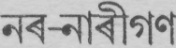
নৰ-নাৰীগণ
